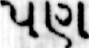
પણ
